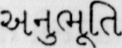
અનુભૂતિ
